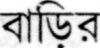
বাড়ির
